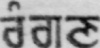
ਰੰਗਣ
